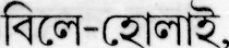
বিলে-হোলাই,
